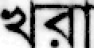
খরা
